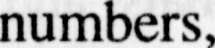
numbers,
